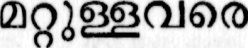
മറ്റുള്ളവരെ
